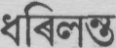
ধৰিলন্ত
